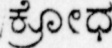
ಕ್ರೋಧ
